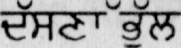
ਦੱਸਣਾੱਭੁੱਲ
